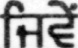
ਜਿਵੇਂ
